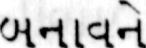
બનાવને
